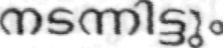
നടന്നിട്ടും
